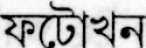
ফটোখন
